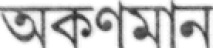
অকণমান
